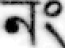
নং
